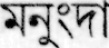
মনুংদা
